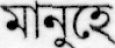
মানুহে
